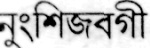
নুংশিজবগী
